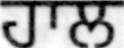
ਹਾਲ
